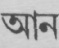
আন
